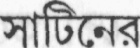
সাটিনের
